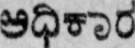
ಅಧಿಕಾರ
